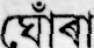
ঘোঁৰা
